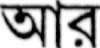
আর
